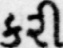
કરી
